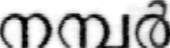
നമ്പര്‍
